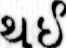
થઈ
